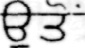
ਉਤੋਂ
